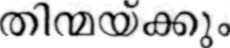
തിന്മയ്ക്കും
